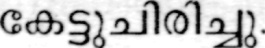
കേട്ടുചിരിച്ചു.
